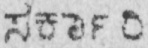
ಸರ್ಕಾರಿ
